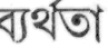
ব্যর্থতা
